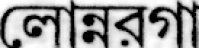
লোন্নরগা
